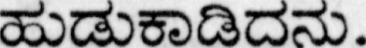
ಹುಡುಕಾಡಿದನು.
